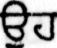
ਉਹ
